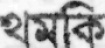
থমকি
